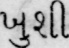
ખુશી
